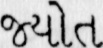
જ્યોત
